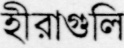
হীরাগুলি
